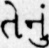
તેનું
